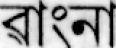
ৱাংনা
